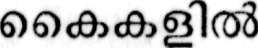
കൈകളില്‍
